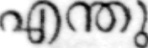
എന്തു
